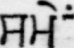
ਸਮੇਂ
